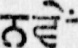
ਨਵੇਂ
